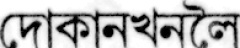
দোকানখনলৈ
